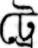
ট্রে
